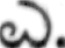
ಎ.
